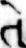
તે
